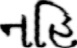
નહિ
